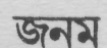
জনম
